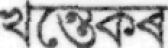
খন্তেকৰ
